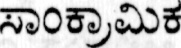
ಸಾಂಕ್ರಾಮಿಕ
